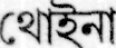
থোইনা
